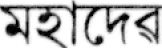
মহাদেৱ
